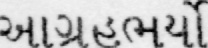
આગ્રહભર્યો
